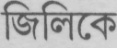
জিলিকে
